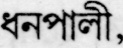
ধনপালী,
